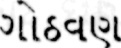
ગોઠવણ
